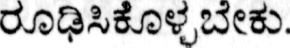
ರೂಢಿಸಿಕೊಳ್ಳಬೇಕು.
